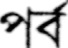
পর্ব
